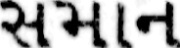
સમાન
